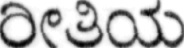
ರೀತಿಯ
